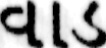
વાડ
